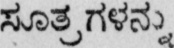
ಸೂತ್ರಗಳನ್ನು
